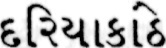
દરિયાકાઠે
